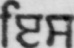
ਇਸ
